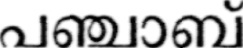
പഞ്ചാബ്
